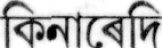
কিনাৰেদি
